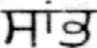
ਸਾਂਭ
